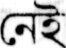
নেই
